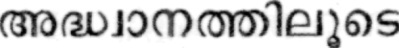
അദ്ധ്വാനത്തിലൂടെ
